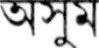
অসুম
